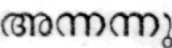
അന്നന്നു
